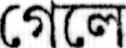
গেলে
